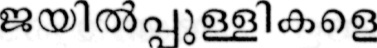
ജയില്‍പ്പുള്ളികളെ
